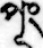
পূং
